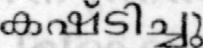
കഷ്ടിച്ചു
